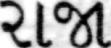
રાજા
